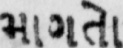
માગતો
